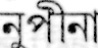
নুপীনা
